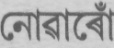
নোৱাৰোঁ
